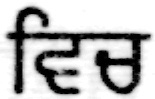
ਵਿਚ
